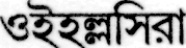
ওইহল্লসিরা
